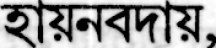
হায়নবদায়,
